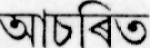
আচৰিত
